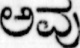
ಅವು
